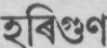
হৰিগুণ
